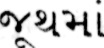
જૂથમાં
